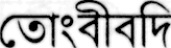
তোংবীবদি
